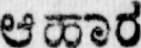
ಆಹಾರ
